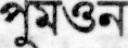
পুমওন
